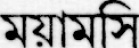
ময়ামসি
